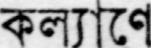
কল্যাণে
